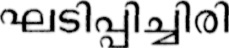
ഘടിപ്പിച്ചിരി
